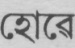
হোৱে
